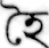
হৈ
